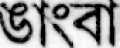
ঙাংবা
